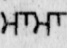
ਮਾਮਾ
